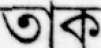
তাক
